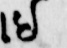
ગઈ
